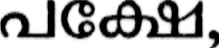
പക്ഷേ,
